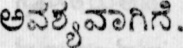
ಅವಶ್ಯವಾಗಿದೆ.
